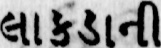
લાકડાની
